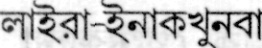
লাইরা-ইনাকখুনবা
